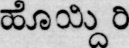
ಹೊಯ್ದಿರಿ
